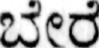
ಬೇರೆ
